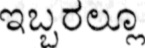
ಇಬ್ಬರಲ್ಲೂ
